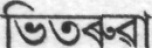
ভিতৰুৱা
